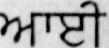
ਆਈ
